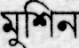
মুশিন
